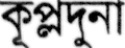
কুপ্লদুনা
